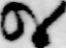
જ
